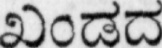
ಖಂಡದ
